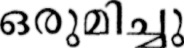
ഒരുമിച്ചു
